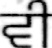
ਵੀ
